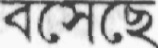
বসেছে
